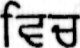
ਵਿਚ
